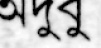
অদুবু
